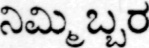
ನಿಮ್ಮಿಬ್ಬರ
